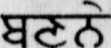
ਬਣਨੇ
